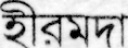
হীরমদা
